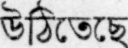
উঠিতেছে
